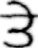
ਤੇ
